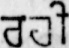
ਰਹੀ
